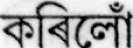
কৰিলোঁ
